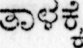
ತಾಳಕ್ಕೆ
